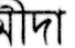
মীদা
